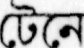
টেনে
